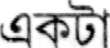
একটা
